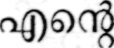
എന്റെ
